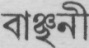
বাঞ্ছনী
